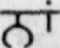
ਨਾਂ
